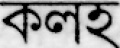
কলহ
